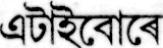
এটাইবোৰে
